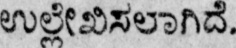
ಉಲ್ಲೇಖಿಸಲಾಗಿದೆ.
